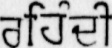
ਰਹਿੰਦੀ
